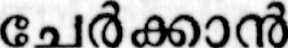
ചേര്‍ക്കാന്‍
